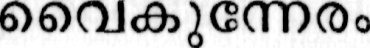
വൈകുന്നേരം
